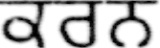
ਕਰਨ
